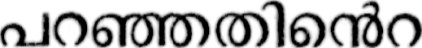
പറഞ്ഞതിന്റെ
